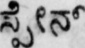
ಸ್ಪೇನ್
